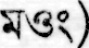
মওং)
